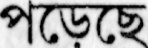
পড়েছে
